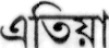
এতিয়া
